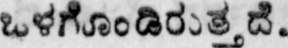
ಒಳಗೊಂಡಿರುತ್ತದೆ.
